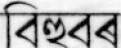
বিহুবৰ
